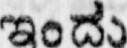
ಇಂದು
